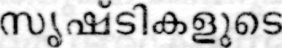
സൃഷ്ടികളുടെ
